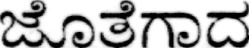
ಜೊತೆಗಾದ
